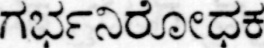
ಗರ್ಭನಿರೋಧಕ
